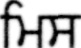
ਮਿਸ
